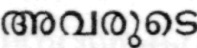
അവരുടെ
